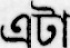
এটা
